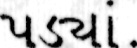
પડ્યાં.
